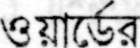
ওয়ার্ডের
